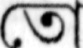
তো
